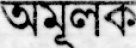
অমূলক
